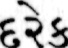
દરેક
